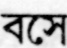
বসে
